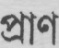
প্ৰাণ
